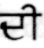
ਦੀ
